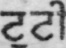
ਟੁਟੀ
